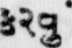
કરવું
